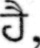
ਹੈ,
